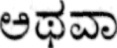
ಅಥವಾ
